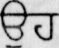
ਉਹ
